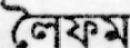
লৈফম
